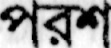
পরশ
